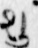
શું
